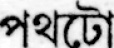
পথটো
